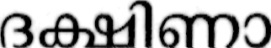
ദക്ഷിണാ
